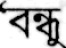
'বন্ধু
